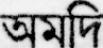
অমদি
